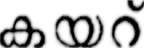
കയറ്
